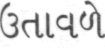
ઉતાવળે
